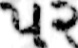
પર
